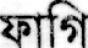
ফাগি
